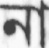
না
